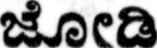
ಜೋಡಿ
